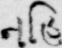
નહિ
